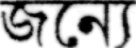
জন্যে
